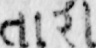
તારી
